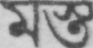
মস্ত
